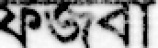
ফজবা
